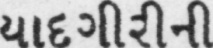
યાદગીરીની
